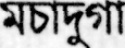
মচাদুগা
